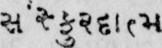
સંસ્ફુરદાત્મ
